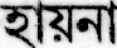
হায়না
